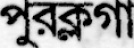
পুরক্লগা
